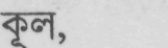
কূল,
